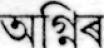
অগ্নিৰ
